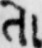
તો
